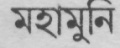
মহামুনি
